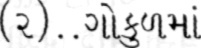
(૨)...ગોકુળમાં
